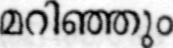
മറിഞ്ഞും
